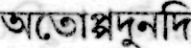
অতোপ্পদুনদি
